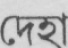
দেহা
